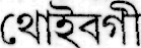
থোইবগী
